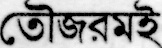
তৌজরমই
